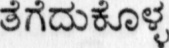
ತೆಗೆದುಕೊಳ್ಳ
